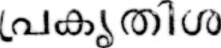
പ്രകൃതിശ
